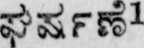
ಘರ್ಷಣೆ1
